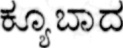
ಕ್ಯೂಬಾದ
